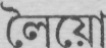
লৈয়ো
